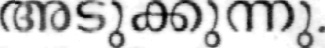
അടുക്കുന്നു.
